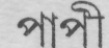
পাপী
